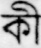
কী
